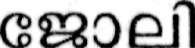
ജോലി
